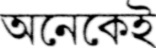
অনেকেই
